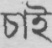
চাই
